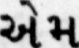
એમ
